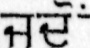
ਜਦੋਂ
